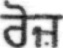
ਰੋਜ਼
